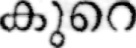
കുറെ
